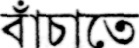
বাঁচাতে
